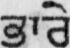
ਭਾਰੇ
